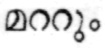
മററും
